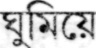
ঘুমিয়ে
